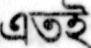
এতই
